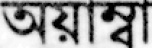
অয়াম্বা
